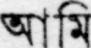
আমি
